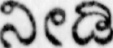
ನೀಡಿ
